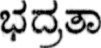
ಭದ್ರತಾ
